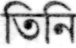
তিনি
